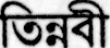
তিন্নবী
